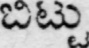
ಬಿಟ್ಟು
